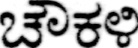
ಚೌಕಳಿ
